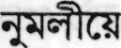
নুমলীয়ে
